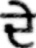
ਦੇ
